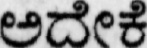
ಅದೇಕೆ
